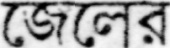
জেলের
